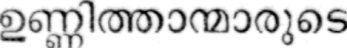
ഉണ്ണിത്താന്മാരുടെ
